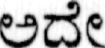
ಅದೇ
